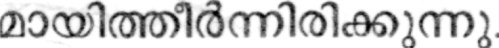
മായിത്തീര്‍ന്നിരിക്കുന്നു.
